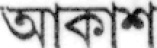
আকাশ
